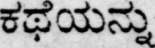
ಕಥೆಯನ್ನು
